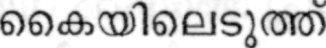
കൈയിലെടുത്ത്
